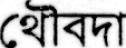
থৌবদা
